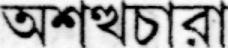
অশত্থচারা
